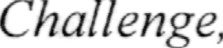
Challenge,
